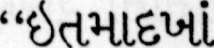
"ઇતમાદખાં
